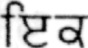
ਇਕ
